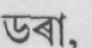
ডৰা,
